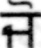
ਜੋ
